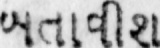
બતાવીશ
